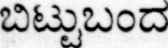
ಬಿಟ್ಟುಬಂದ
